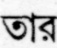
তার
